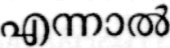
എന്നാല്‍
